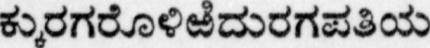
ಕ್ಕುರಗರೊಳಿಱದುರಗಪತಿಯ
